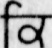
ਕਿ
